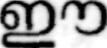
ഈ
